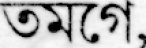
তমগে,
